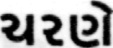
ચરણે
